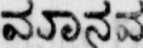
ಮಾನವ
